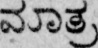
ಮಾತ್ರ
